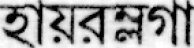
হায়রম্লগা
